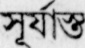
সূর্যাস্ত
